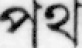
পথ
